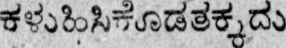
ಕಳುಹಿಸಿಕೊಡತಕ್ಕದು
